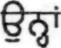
ਉਨ੍ਹਾਂ
